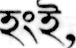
হংই,
